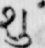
શું
